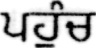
ਪਹੁੰਚ
